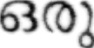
ഒരു
